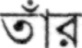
তাঁর
